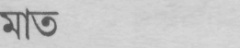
মাত
